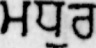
ਮਧੁਰ
